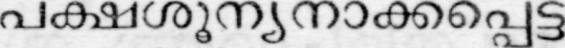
പക്ഷശൂന്യനാക്കപ്പെട്ട
